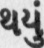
થયું
